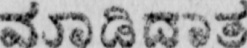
ಮಾಡಿದಾತ
